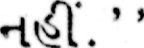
નહીં."
